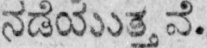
ನಡೆಯುತ್ತವೆ.
